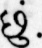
છું.
